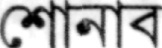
শোনাব
